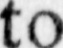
to
